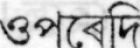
ওপৰেদি
